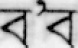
ব'ব
